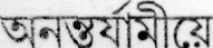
অনন্তর্যামীয়ে
